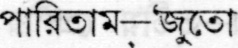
পারিতাম—‘জুতো
